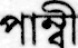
পাম্বী
